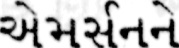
એમર્સનને
